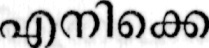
എനിക്കെ
